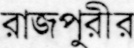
রাজপুরীর
